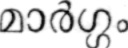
മാര്‍ഗ്ഗം
